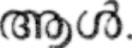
ആള്‍.
